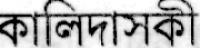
কালিদাসকী
